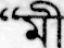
“মী
